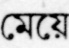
মেয়ে
